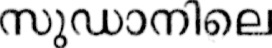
സുഡാനിലെ
